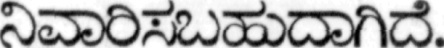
ನಿವಾರಿಸಬಹುದಾಗಿದೆ.
